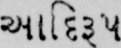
આદિરૂપ
